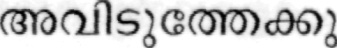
അവിടുത്തേക്കു
